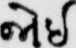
જોઈ
